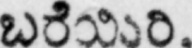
ಬರೆಯಿರಿ.
